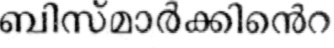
ബിസ്മാര്‍ക്കിന്റെ
